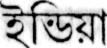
ইন্ডিয়া
